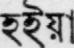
হইয়া
